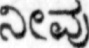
ನೀವು
